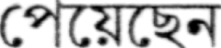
পেয়েছেন
